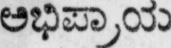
ಅಭಿಪ್ರಾಯ
